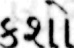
કશો
